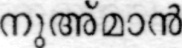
നുഅ്മാന്‍
